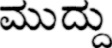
ಮುದ್ದು
